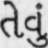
તેવું
